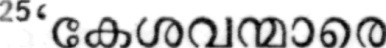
25'കേശവന്മാരെ
